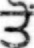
ਤੋਂ
